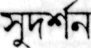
সুদর্শন
